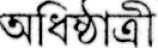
অধিষ্ঠাত্রী
